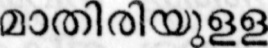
മാതിരിയുള്ള
